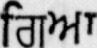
ਗਿਆ
